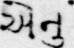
એનું
